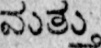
ಮತ್ತು
